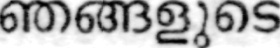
ഞങ്ങളുടെ
